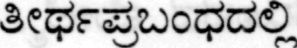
ತೀರ್ಥಪ್ರಬಂಧದಲ್ಲಿ
